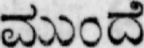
ಮುಂದೆ
